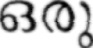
ഒരു
